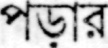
পড়ার
